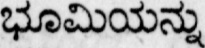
ಭೂಮಿಯನ್ನು
